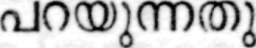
പറയുന്നതു
